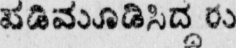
ಪಡಿಮೂಡಿಸಿದ್ದರು
